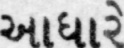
આધારે
